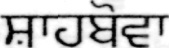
ਸ਼ਾਹਬੋਵਾ
